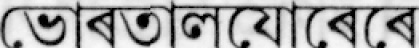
ভোৰতালযোৰেৰে
